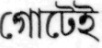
গোটেই
